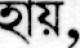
হায়,
